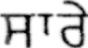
ਸਾਰੇ
